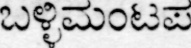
ಬಳ್ಳಿಮಂಟಪ
